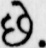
છે.
